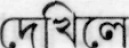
দেখিলে
